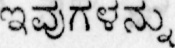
ಇವುಗಳನ್ನು
